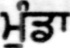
ਮੁੰਡਾ
